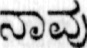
ನಾವು
